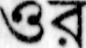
ওর
